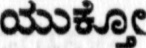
ಯುಕ್ತೋ
